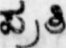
ಪ್ರತಿ
